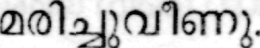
മരിച്ചുവീണു.
